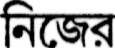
নিজের
